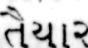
તૈયાર
